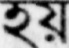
হয়
